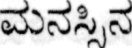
ಮನಸ್ಸಿನ
